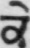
ਕੇ
